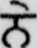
ਨੇ
